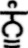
ਨੂੰ
